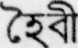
হৈবী
